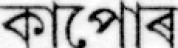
কাপোৰ
